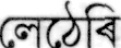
লেঠেৰি
